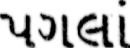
પગલાં
